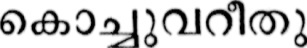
കൊച്ചുവറീതു
